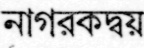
নাগরকদ্বয়
